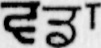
ਵਡਾ
